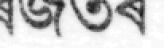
ৰজতৰ
